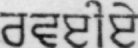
ਰਵਈਏ
